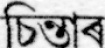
চিন্তাৰ
